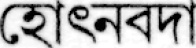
হোৎনবদা
